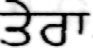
ਤੇਰਾ
